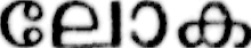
ലോക
